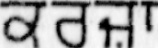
ਕਰਜ਼ਾ
